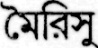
মৈরিসু
